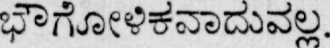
ಭೌಗೋಳಿಕವಾದುವಲ್ಲ.
